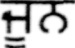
ਜੂਨ
